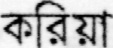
করিয়া
